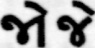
જોજે
